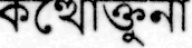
কত্থোক্তুনা
